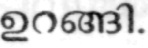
ഉറങ്ങി.
